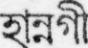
হান্নগী
